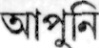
আপুনি
